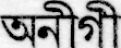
অনীগী
